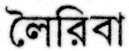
লৈরিবা
